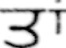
ਤਾਂ
